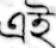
এই
